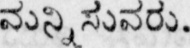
ಮನ್ನಿಸುವರು.
